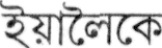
ইয়ালৈকে
